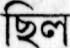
ছিল
